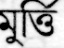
মুর্ত্তি
